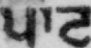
ਪਾਟ
